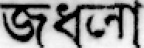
জধনো
